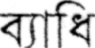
ব্যাধি
